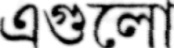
এগুলো
